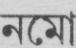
নমো
